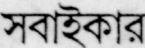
সবাইকার
